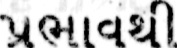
પ્રભાવથી
